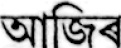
আজিৰ
